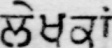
ਲੇਖਕਾਂ
